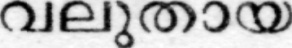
വലുതായ
